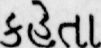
કહેતા
